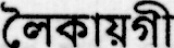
লৈকায়গী
